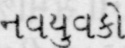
નવયુવકો
